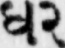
ઘર
